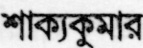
শাক্যকুমার
